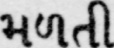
મળતી
